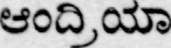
ಆ೦ದ್ರಿಯಾ
